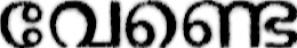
വേണ്ടെ
